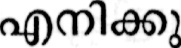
എനിക്കു
